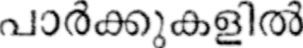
പാര്‍ക്കുകളില്‍
